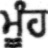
ਮੂੰਹ
